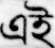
এই
